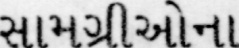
સામગ્રીઓના
